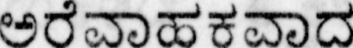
ಅರೆವಾಹಕವಾದ
